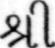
શ્રી
